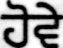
ਹੋਵੇ
